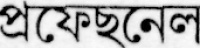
প্রফেছনেল
